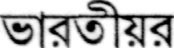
ভারতীয়র
